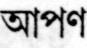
আপণ
